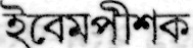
ইবেমপীশক
